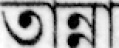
তান্না
